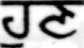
ਹੁਣ
